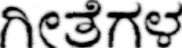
ಗೀತೆಗಳ
